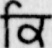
ਕਿ
